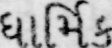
ધાર્મિક
